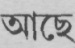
আছে
